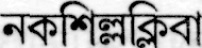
নকশিল্লক্লিবা
